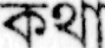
কথা
